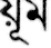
য়ূম
